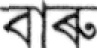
বাৰু
